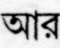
আর
